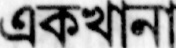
একখানা
